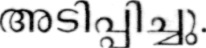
അടിപ്പിച്ചു.
